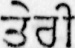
ਤੇਰੀ
